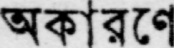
অকারণে
